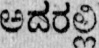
ಅದರಲ್ಲಿ
